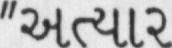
"અત્યાર
